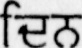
ਦਿਨ
